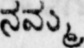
ನಮ್ಮ
